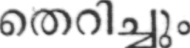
തെറിച്ചും
